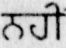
ਨਹੀਂ
